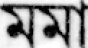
মমা
